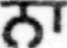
ਨਾ
